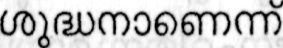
ശുദ്ധനാണെന്ന്
